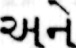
અને
